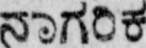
ನಾಗರಿಕ
